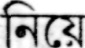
নিয়ে
